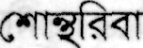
শোন্থরিবা
